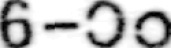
6-ാം
